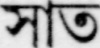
সাত
